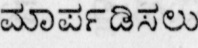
ಮಾರ್ಪಡಿಸಲು
